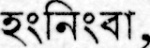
হংনিংবা,
